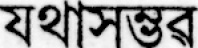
যথাসম্ভৱ
